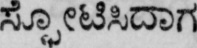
ಸ್ಫೋಟಿಸಿದಾಗ
